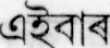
এইবাৰ
